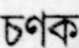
চণক
